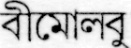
বীমোলবু
